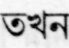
তখন
